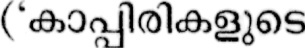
('കാപ്പിരികളുടെ
